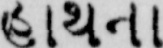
હાથના
